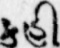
કહી
